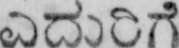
ಎದುರಿಗೆ
